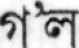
গ'ল
